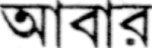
আবার
